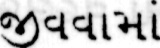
જીવવામાં
